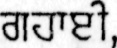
ਗਹਾਈ,
